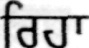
ਰਿਹਾ
